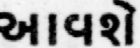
આવશે
